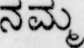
ನಮ್ಮ
